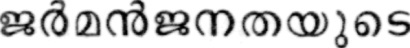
ജര്‍മന്‍ജനതയുടെ
